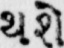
થશે
